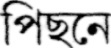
পিছনে
